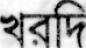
খরদি
